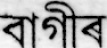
বাগীৰ
